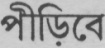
পীড়িবে
